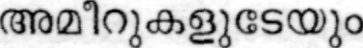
അമീറുകളുടേയും
